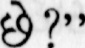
છે?"
